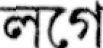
লগে
